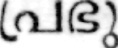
പ്രഭു
